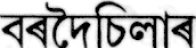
বৰদৈচিলাৰ
